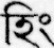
হিং
